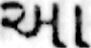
આ
